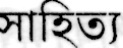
সাহিত্য
